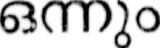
ഒന്നും
